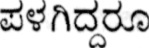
ಪಳಗಿದ್ದರೂ
